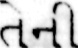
તેની
